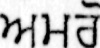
ਅਮਰੋ
